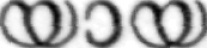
യായ
